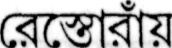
রেস্তোরাঁয়
